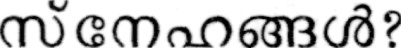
സ്നേഹങ്ങള്‍?
